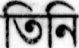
তিনি
